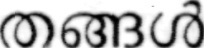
തങ്ങള്‍
